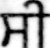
ਸੀ
